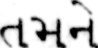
તમને
